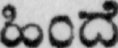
ಹಿಂದೆ
